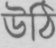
উঠি
